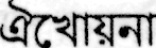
ঐখোয়না
